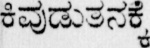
ಕಿವುಡುತನಕ್ಕೆ
